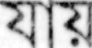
যায়
